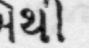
એથી
